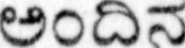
ಅಂದಿನ
